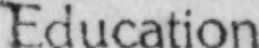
Education
